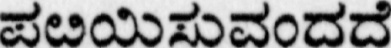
ಪೞಯಿಸುವಂದದೆ
